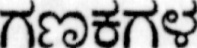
ಗಣಕಗಳ
